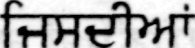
ਜਿਸਦੀਆਂ
